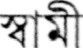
স্বামী
